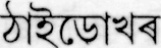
ঠাইডোখৰ
